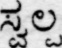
ಸ್ವಲ್ಪ
